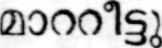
മാററീട്ടു
